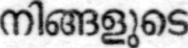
നിങ്ങളുടെ
